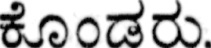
ಕೊಂಡರು.
